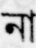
না
